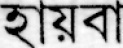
হায়বা
